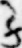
કે
